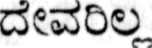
ದೇವರಿಲ್ಲ
